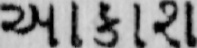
આકાશ
